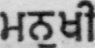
ਮਨੁਖੀ
